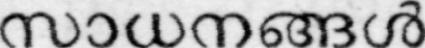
സാധനങ്ങള്‍
